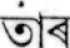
তাৰ
